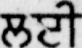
ਲਈ
